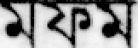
মফম
